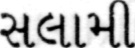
સલામી
